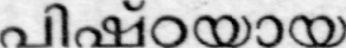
പിഷ്ഠയായ
